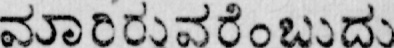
ಮಾರಿರುವರೆಂಬುದು
